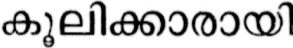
കൂലിക്കാരായി
